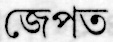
জেপত
